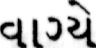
વાગ્યે
